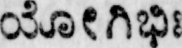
ಯೋಗಿರ್ಭಿ
